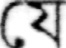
যে
